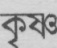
কৃষ্ণ
